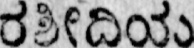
ರಶೀದಿಯ
